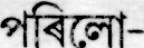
পৰিলো-
